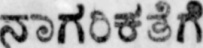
ನಾಗರಿಕತೆಗೆ
